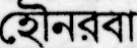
হৌনরবা
